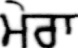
ਮੇਰਾ
